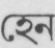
হেন
